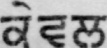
ਕੇਵਲ
